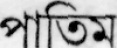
পাতিম
